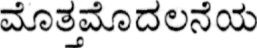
ಮೊತ್ತಮೊದಲನೆಯ
